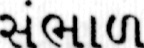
સંભાળ
